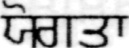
ਯੋਗਤਾ
